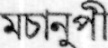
মচানুপী
